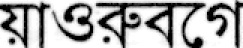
য়াওরুবগে
